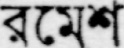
রমেশ
